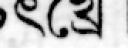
চৎখ্রে
